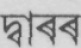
দ্বাৰৰ
